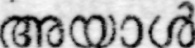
അയാള്‍
